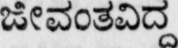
ಜೀವಂತವಿದ್ದ
